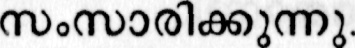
സംസാരിക്കുന്നു.
